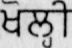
ਖੋਲ੍ਹੀ
